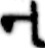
ન
